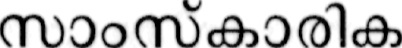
സാംസ്കാരിക
